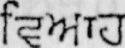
ਵਿਆਹ
